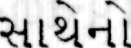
સાથેનો
